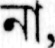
না,
